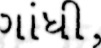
ગાંધી,
